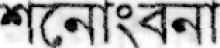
শনোংবনা
